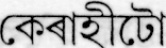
কেৰাহীটো
